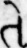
તે
